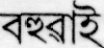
বহুৱাই
